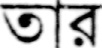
তার
